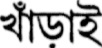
খাঁড়াই
